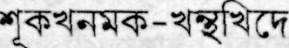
শূকখনমক-খন্থখিদে
